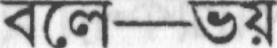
বলে-ভয়
